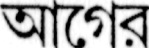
আগের
